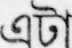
এটা
